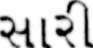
સારી
